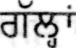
ਗੱਲ੍ਹਾਂ
